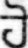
ਹੋ
